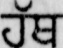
ਹੱਥ
